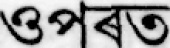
ওপৰত
